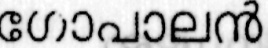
ഗോപാലന്‍
